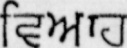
ਵਿਆਹ
